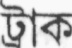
ট্রাক
